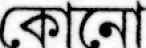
কোনো
